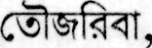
তৌজরিবা,
